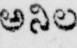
ಅನಿಲ
